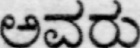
ಅವರು
